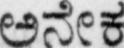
ಅನೇಕ
